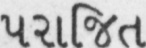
પરાજિત
